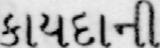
કાયદાની
